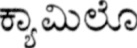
ಕ್ಯಾಮಿಲೊ
